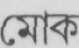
মোক
